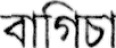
বাগিচা
